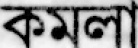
কমলা
